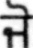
ਜੋ
